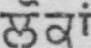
ਲੋਕਾਂ
